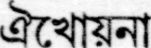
ঐখোয়না
